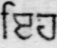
ਇਹ
